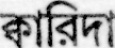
ক্বারিদা
